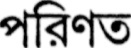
পরিণত
